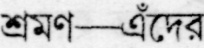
শ্রমণ–এঁদের
